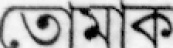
তোমাক
